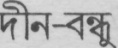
দীন-বন্ধু
